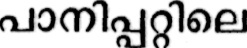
പാനിപ്പറ്റിലെ
